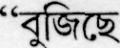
"বুজিছে
